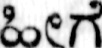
ಹೀಗೆ
